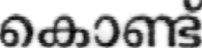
കൊണ്ട്
